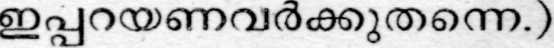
ഇപ്പറയണവര്‍ക്കുതന്നെ.)
